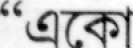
"একো
